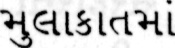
મુલાકાતમાં
